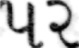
પર
